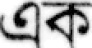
এক
